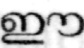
ഈ
